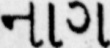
નાગ
